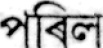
পৰিল
